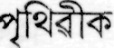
পৃথিৱীক
